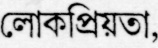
লোকপ্রিয়তা,
